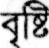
বৃষ্টি
